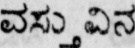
ವಸ್ತುವಿನ
